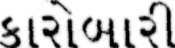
કારોબારી
